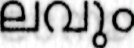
ലവും
